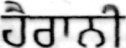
ਹੈਰਾਨੀ
